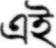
এই
